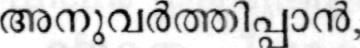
അനുവര്‍ത്തിപ്പാന്‍,
